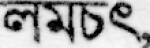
লমচৎ,
